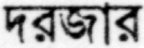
দরজার
